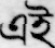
এই
